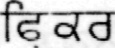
ਫ਼ਿਕਰ
